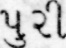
પુરી
